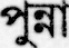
পুন্না
